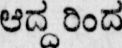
ಆದ್ದರಿಂದ
